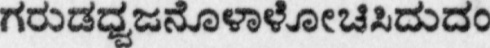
ಗರುಡಧ್ವಜನೊಳಾಳೋಚಿಸಿದುದಂ
